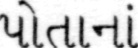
પોતાનાં
